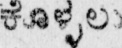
ಕೊಳ್ಳಲು
